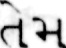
તેમ
